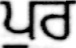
ਪੁਰ
